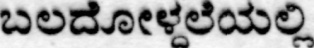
ಬಲದೋಳ್ದಲೆಯಲ್ಲಿ
